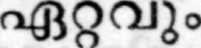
ഏറ്റവും
